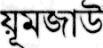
য়ূমজাউ
